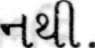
નથી.
